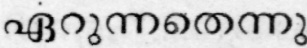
ഏറുന്നതെന്നു
